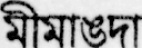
মীমাঙদা
